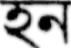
হন
